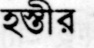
হস্তীর
